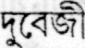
দুবেজী
